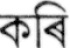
কৰি
